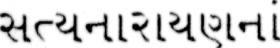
સત્યનારાયણનાં
